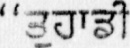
''ਤੁਹਾਡੀ
